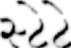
સ્ટેટે
